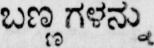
ಬಣ್ಣಗಳನ್ನು
